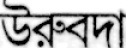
উরুবদা
